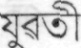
যুৱতী
